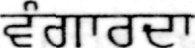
ਵੰਗਾਰਦਾ
